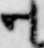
ન
